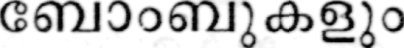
ബോംബുകളും
